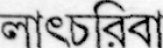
লাৎচরিবা
